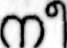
നീ
